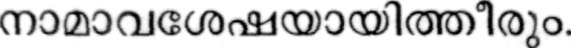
നാമാവശേഷയായിത്തീരും.
